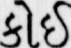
કોઈ
